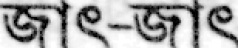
জাৎ-জাৎ
